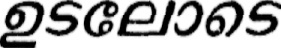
ഉടലോടെ
